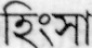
হিংসা
